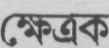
ক্ষেত্ৰক
